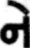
ને
